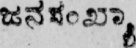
ಜನಸಂಖ್ಯಾ
